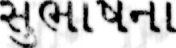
સુભાષના
